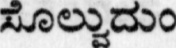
ಸೊಲ್ವುದುಂ
